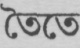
তৈতে
